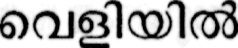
വെളിയില്‍
